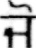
ਜੋ
